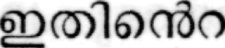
ഇതിന്റെ
